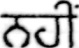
ਨਹੀਂ
